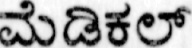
ಮೆಡಿಕಲ್
